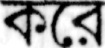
করে
